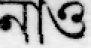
নাও
